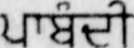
ਪਾਬੰਦੀ
